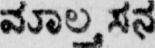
ಮಾಲ್ತಸನ
